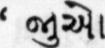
'જુઓ
